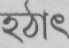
হঠাৎ
